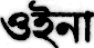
ওইনা
